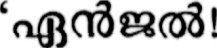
‘ഏന്‍ജല്‍!
